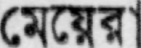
মেয়েরা
